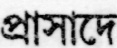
প্রাসাদে
